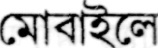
মোবাইলে
